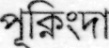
পূক্নিংদা
